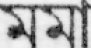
মমা
